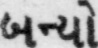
બન્યો
